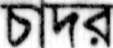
চাদর
